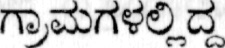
ಗ್ರಾಮಗಳಲ್ಲಿದ್ದ
